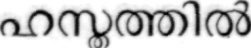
ഹസ്തത്തില്‍
